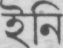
ইনি
